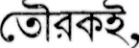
তৌরকই,
